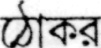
ঠোকর
